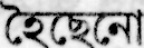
হৈছেনো
